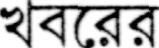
খবরের
